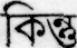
কিন্তু
